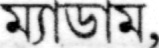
ম্যাডাম,
